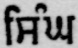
ਸਿੰਘ
